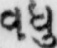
વધુ
